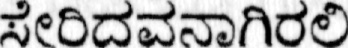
ಸೇರಿದವನಾಗಿರಲಿ
